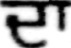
ਦਾ
